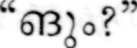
"ങും?"
